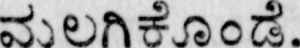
ಮಲಗಿಕೊಂಡೆ.
